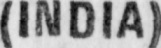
(INDIA)
